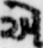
એ
